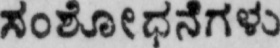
ಸಂಶೋಧನೆಗಳು
